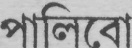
পালিবো
